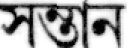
সন্তান
